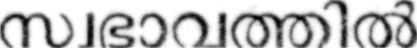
സ്വഭാവത്തില്‍
